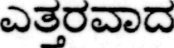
ಎತ್ತರವಾದ
